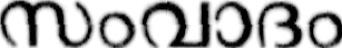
സംവാദം
